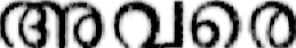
അവരെ
